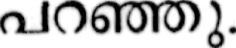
പറഞ്ഞു.
